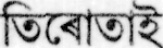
তিৰোতাই
